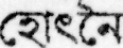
হোৎনৈ
